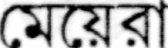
মেয়েরা
